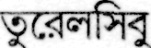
তুরেলসিবু
